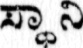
ಸ್ಥಾನಿ
